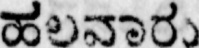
ಹಲವಾರು
